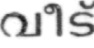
വീട്
